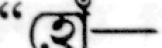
"হোঁ-
